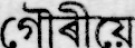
গৌৰীয়ে
